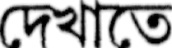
দেখাতে
